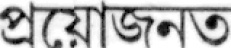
প্রয়োজনত
